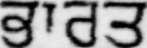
ਭਾਰਤ
